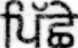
ਪਿੱਛੇ
